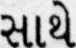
સાથે
